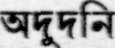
অদুদনি
